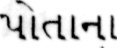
પોતાના
